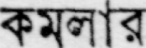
কমলার
